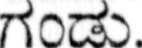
ಗಂಡು.
